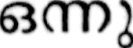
ഒന്നു
